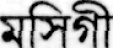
মসিগী
